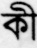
কী
